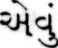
એવું
